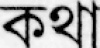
কথা
